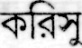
করিসু
